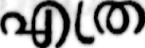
എത്ര
